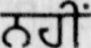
ਨਹੀਂ
